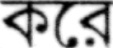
করে
